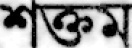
শক্তম
